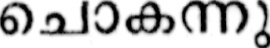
ചൊകന്നു
